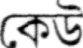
কেউ
